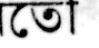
নতৌ
